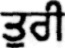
ਤੁਰੀ
